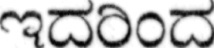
ಇದರಿಂದ
